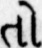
તો
